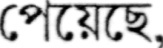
পেয়েছে,
